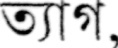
ত্যাগ,
